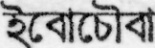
ইবোচৌবা
